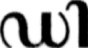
ഡി
